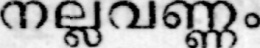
നല്ലവണ്ണം
